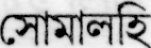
সোমালহি
